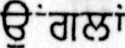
ਉਂਗਲਾਂ
